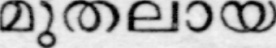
മുതലായ
